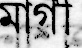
মাগী
